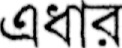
এধার
